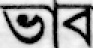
ভাব
